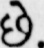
છે.
